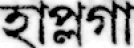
হাপ্লগা
